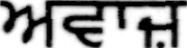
ਅਵਾਜ਼
